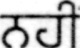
ਨਹੀਂ
